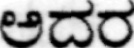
ಅದರ
